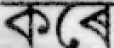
কৰে
